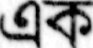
এক
